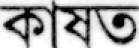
কাষত
